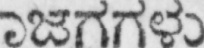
ಜಾಗಗಳು
